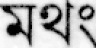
মথং
